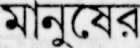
মানুষের
